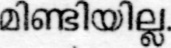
മിണ്ടിയില്ല.
